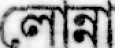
লোন্না
